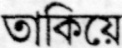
তাকিয়ে
